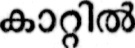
കാറ്റില്‍
